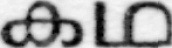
കഥ
